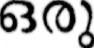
ഒരു
